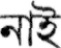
নাই
